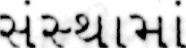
સંસ્થામાં
